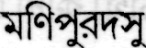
মণিপুরদসু
